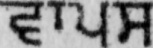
ਵਾਪਸ
